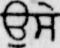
ਉਸੇ
